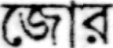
জোর
